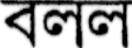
বলল
